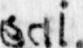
હતાં,
